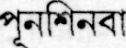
পূনশিনবা
